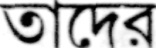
তাদের
